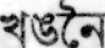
খঙনৈ
